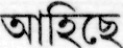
আহিছে
